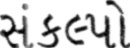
સંકલ્પો
